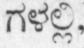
ಗಳಲ್ಲಿ,
